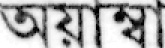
অয়াম্বা
